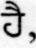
ਹੈ,
